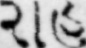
રાહ
